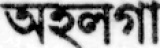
অহলগা
